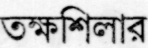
তক্ষশিলার
